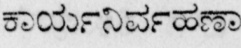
ಕಾರ್ಯನಿರ್ವಹಣಾ
